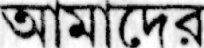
আমাদের
